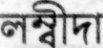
লম্বীদা
